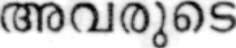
അവരുടെ
